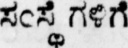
ಸಂಸ್ಥೆಗಳಿಗೆ
